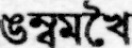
ঙম্বমখৈ
